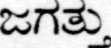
ಜಗತ್ತು
